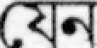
যেন
